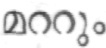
മററും
